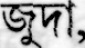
জুদা,
